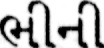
ભીની
